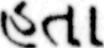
હતા
